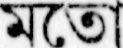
মতো
